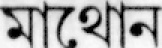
মাথোন
